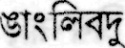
ঙাংলিবদু
